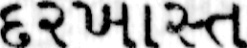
દરખાસ્ત
